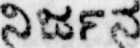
ನಿರ್ಜನ
